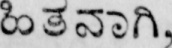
ಹಿತವಾಗಿ,
